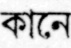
কানে
